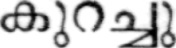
കുറച്ചു
